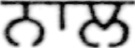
ਨਾਲ
